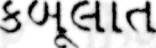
કબૂલાત
